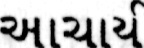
આચાર્ય
